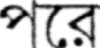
পরে
